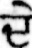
ਦੇ
